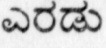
ಎರಡು
